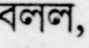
বলল,
